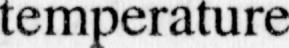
temperature
